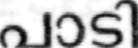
പാടി
